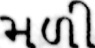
મળી
